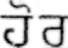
ਹੋਰ
